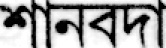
শানবদা
